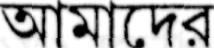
আমাদের
